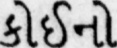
કોઈનો
